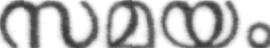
സമയം
